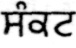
ਸੰਕਟ
